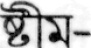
ষ্টীম-
